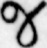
જ
